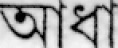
আধা
